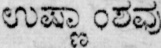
ಉಷ್ಣಾಂಶವು
